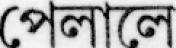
পেলালে
